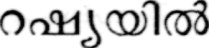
റഷ്യയില്‍
